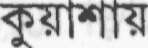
কুয়াশায়
